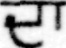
ਦਾ
